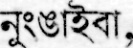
নুংঙাইবা,
